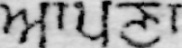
ਆਪਣਾ
